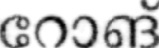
റോങ്
